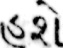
હશે
